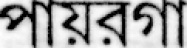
পায়রগা
